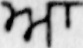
ਆ
